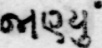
જાણ્યું
